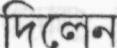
দিলেন
